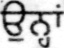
ਉਨ੍ਹਾਂ
